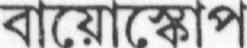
বায়োস্কোপ
